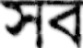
সব
